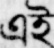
এই
